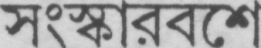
সংস্কারবশে
